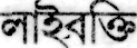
লাইবক্তি
